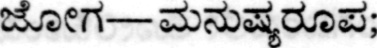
ಜೋಗ-ಮನುಷ್ಯರೂಪ;
